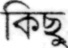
কিছু
